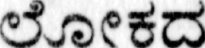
ಲೋಕದ
